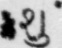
કશું
